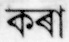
কৰা
